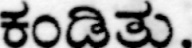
ಕಂಡಿತು.
